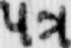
પત્ર
